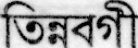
তিন্নবগী
